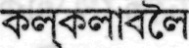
কল্‌কলাবলৈ
